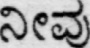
ನೀವು
